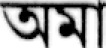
অমা
